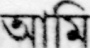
আমি
